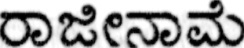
ರಾಜೀನಾಮೆ
